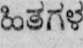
ಹಿತಗಳ
